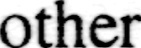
other
